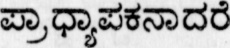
ಪ್ರಾಧ್ಯಾಪಕನಾದರೆ
